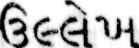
ઉલ્લેખ
